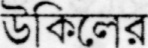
উকিলের
